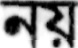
নয়
